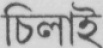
চিলাই
